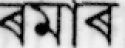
ৰমাৰ
